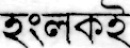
হংলকই
